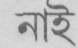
নাই
